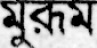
মুরূম
